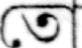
তো
